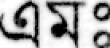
এমঃ
